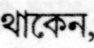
থাকেন,
